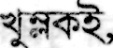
খুম্লকই,
